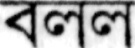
বলল
